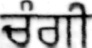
ਚੰਗੀ
